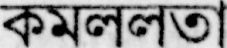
কমললতা
